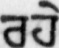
ਰਹੇ
